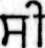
ਸੀ
